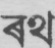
ৰথ
